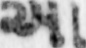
આ
